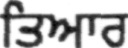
ਤਿਆਰ
